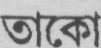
তাকো
